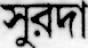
সুরদা
